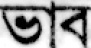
ভাব
